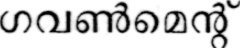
ഗവണ്‍മെന്റ്
